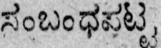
ಸಂಬಂಧಪಟ್ಟ
